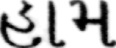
હામ
